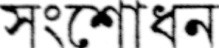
সংশোধন
